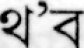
থ'ব
